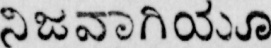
ನಿಜವಾಗಿಯೂ
